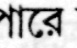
পারে
